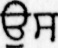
ਉਸ
